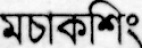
মচাকশিং
